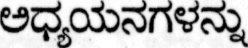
ಅಧ್ಯಯನಗಳನ್ನು
